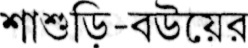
শাশুড়ি-বউয়ের
